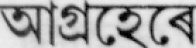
আগ্ৰহেৰে
